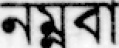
নম্নবা
